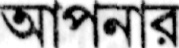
আপনার
